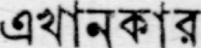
এখানকার
